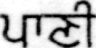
ਪਾਣੀ
